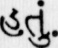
હતું.
